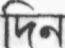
দিন
